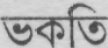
ভকতি
